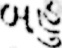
બહુ
